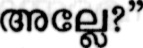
അല്ലേ?”
